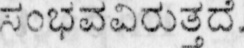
ಸಂಭವವಿರುತ್ತದೆ.
